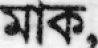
মাক,
